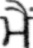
ਮੈਂ
